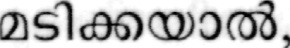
മടിക്കയാല്‍,
